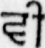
ਵੀ
